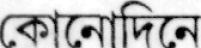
কোনোদিনে
